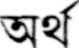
অর্থ
